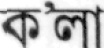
ক'লা
